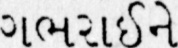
ગભરાઈને
